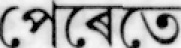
পেৰেতে
